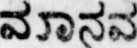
ಮಾನವ
